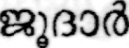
ജൂദാര്‍
